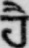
ਹੈ
